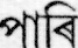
পাৰি
